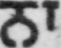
ਨਾ
